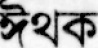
ঈথক
